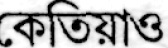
কেতিয়াও
